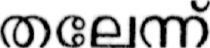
തലേന്ന്
